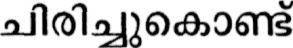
ചിരിച്ചുകൊണ്ട്
